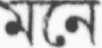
মনে
